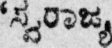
‘ಸ್ವರಾಜ್ಯ
